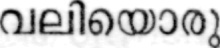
വലിയൊരു
